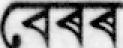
বেৰৰ
